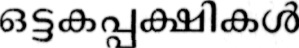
ഒട്ടകപ്പക്ഷികള്‍
